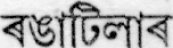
ৰঙাটিলাৰ
